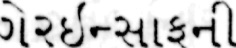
ગેરઈન્સાફની
